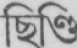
ছিণ্ডি
